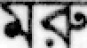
মরু
